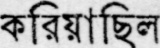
করিয়াছিল
